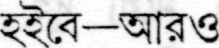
হইবে—আরও
